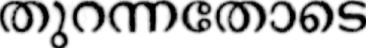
തുറന്നതോടെ
